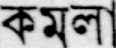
কমলা
